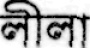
লীলা
